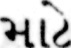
માટે
